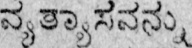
ವ್ಯತ್ಯಾಸವನ್ನು
